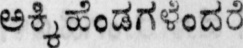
ಅಕ್ಕಿಹೆಂಡಗಳೆಂದರೆ
